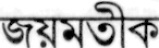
জয়মতীক
